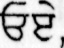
ਓਏ,
